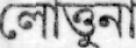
লোত্তুনা
